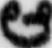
ಆ
